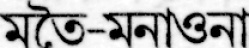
মতৈ-মনাওনা
